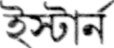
ইস্টার্ন
